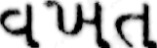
વખત
